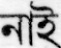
নাই
